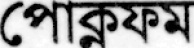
পোক্নফম
